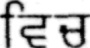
ਵਿਚ
